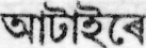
আটাইৰে
